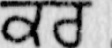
ਕਰ
